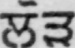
ਲੋੜ
